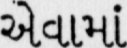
એવામાં
